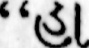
"હા
